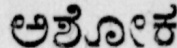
ಅಶೋಕ
